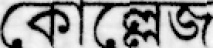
কোল্লেজ
